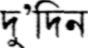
দু’দিন
